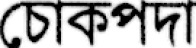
চোকপদা
